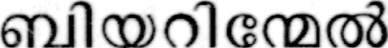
ബിയറിന്മേല്‍
